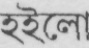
হইলো
